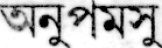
অনুপমসু
